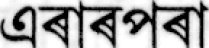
এৰাৰপৰা
